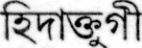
হিদাক্তুগী
